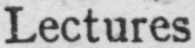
Lectures
